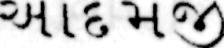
આદમજી
